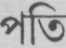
পতি
